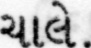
ચાલે.
